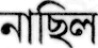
নাছিল
